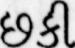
છકી
